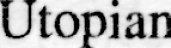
Utopian
